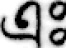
এঃ
